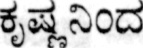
ಕೃಷ್ಣನಿಂದ
